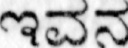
ಇವನ
